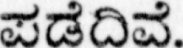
ಪಡೆದಿವೆ.
